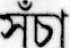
সঁচা
